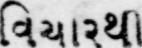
વિયારથી
